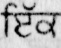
ਇੱਕ
